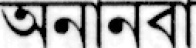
অনানবা
